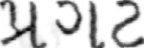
પ્રગટ
